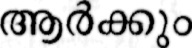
ആര്‍ക്കും
